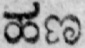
ಹಣ
